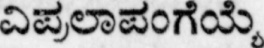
ವಿಪ್ರಲಾಪಂಗೆಯ್ಯೆ
